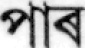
পাৰ
